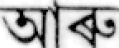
আৰু
